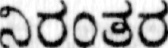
ನಿರಂತರ
